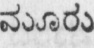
ಮೂರು
